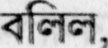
বলিল,
